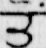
ਤੋਂ
